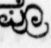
ಪ್ರೊ
